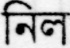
নিল
